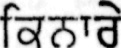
ਕਿਨਾਰੇ
